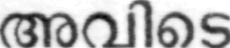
അവിടെ
